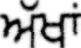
ਅੱਖਾਂ
